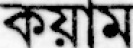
কয়াম
